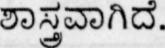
ಶಾಸ್ತ್ರವಾಗಿದೆ.
